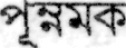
পূম্নমক
